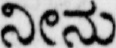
ನೀನು
